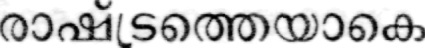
രാഷ്ട്രത്തെയാകെ
